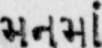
મનમાં
